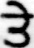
ਤੇ
